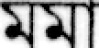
মমা
